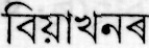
বিয়াখনৰ
